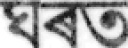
ঘৰত
